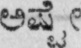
ಅಷ್ಟೇ
